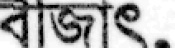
বীজিাৎ
